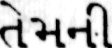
તેમની
